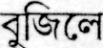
বুজিলে
